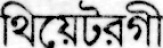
থিয়েটরগী
